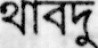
থাবদু
